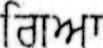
ਗਿਆ
